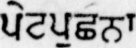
ਪੇਟਪੁਛਨਾ
